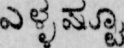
ಎಳ್ಳಷ್ಟೂ
